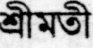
শ্রীমতী
